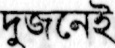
দুজনেই
